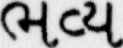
ભવ્ય
